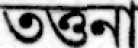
তত্তনা
